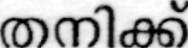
തനിക്ക്
